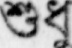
শুধু
